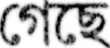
গেছে
